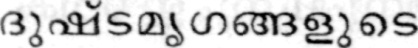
ദുഷ്ടമൃഗങ്ങളുടെ
